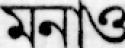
মনাও
